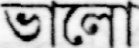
ভালো
